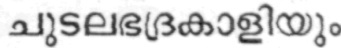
ചുടലഭദ്രകാളിയും
